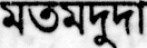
মতমদুদা
